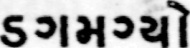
ડગમગ્યો
